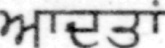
ਆਦਤਾਂ
